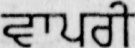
ਵਾਪਰੀ
